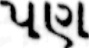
પણ
